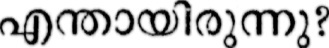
എന്തായിരുന്നു?
